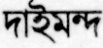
দাইমন্দ
